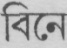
বিনে
